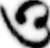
ও
